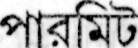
পারমিট
